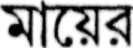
মায়ের
